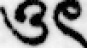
ওৎ
